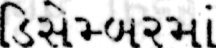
ડિસેમ્બરમાં
